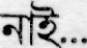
নাই...
